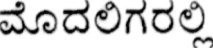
ಮೊದಲಿಗರಲ್ಲಿ
